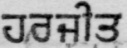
ਹਰਜੀਤ
